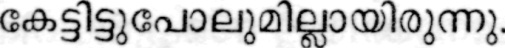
കേട്ടിട്ടുപോലുമില്ലായിരുന്നു.
